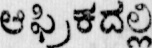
ಆಫ್ರಿಕದಲ್ಲಿ
